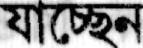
যাচ্ছেন
